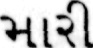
મારી
